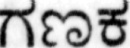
ಗಣಕ
